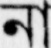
না
